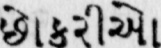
છોકરીઓ
